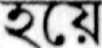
হয়ে
